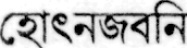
হোৎনজবনি
